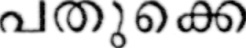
പതുക്കെ
